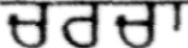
ਚਰਚਾ
